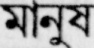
মানুষ
